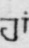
ਹਾਂ
